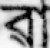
ৱা
